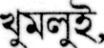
খুমলুই,
